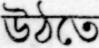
উঠতে
